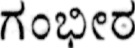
ಗಂಭೀರ
